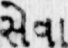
સેવા
